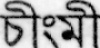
চীংমী
